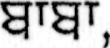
ਬਾਬਾ,
